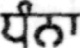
ਧੰਨਾ
